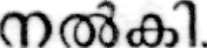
നല്‍കി.
